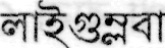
লাইগুম্লবা
